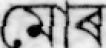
মোৰ
